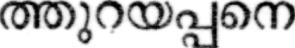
ത്തുറയപ്പനെ
